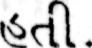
હતી.
